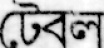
টেবল
